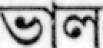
ভাল
